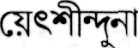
য়েৎশীন্দুনা
